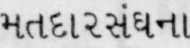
મતદારસંઘના
